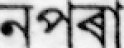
নপৰা
